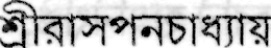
শ্রীরাসপনচাধ্যায়
